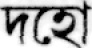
দহো
